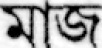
মাজ
